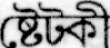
ষ্টেটকী
